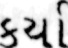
કર્યા
